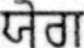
ਯੋਗ
